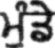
ਮੁੰਡੇ
